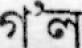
গ'ল
